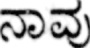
ನಾವು
